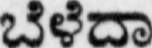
ಬೆಳೆದಾ
